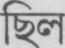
ছিল
